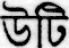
উটি
